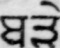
ਬੜੇ
